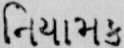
નિયામક
